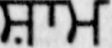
ਸ਼ਾਮ
